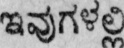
ಇವುಗಳಲ್ಲಿ
